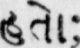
હતો;
